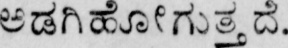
ಅಡಗಿಹೋಗುತ್ತದೆ.
